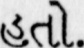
હતો.
